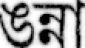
ঙন্না
